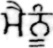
ਮੈਨੂੰ
